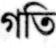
গতি
